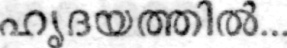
ഹൃദയത്തില്‍...
